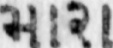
મારા
